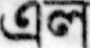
এল
